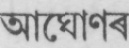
আঘোণৰ
